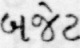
બજેટ
